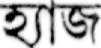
হ্যাজ
